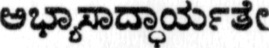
ಅಭ್ಯಾಸಾದ್ಧಾರ್ಯತೇ
